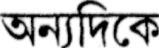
অন্যদিকে
